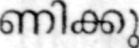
ണിക്കു
